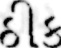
ઠીક
